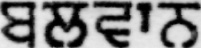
ਬਲਵਾਨ
